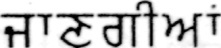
ਜਾਣਗੀਆਂ
